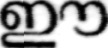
ഈ
